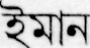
ইমান
